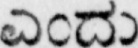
ಎಂದು
